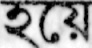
হয়ে
